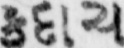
કદાચ
